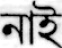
নাই
